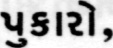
પુકારો,
